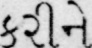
કરીને
